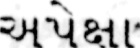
અપેક્ષા
